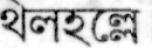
থিলহল্লে
